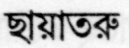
ছায়াতরু
